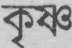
কৃষ্ণ
